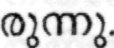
രുന്നു.
